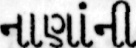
નાણાંની
